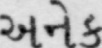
અનેક
